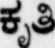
ಕೃತಿ
